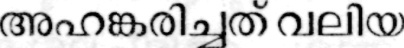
അഹങ്കരിച്ചത്‌ വലിയ
